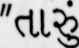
"તારું
